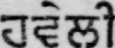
ਹਵੇਲੀ
